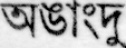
অঙাংদু
